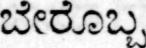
ಬೇರೊಬ್ಬ
